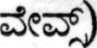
ವೇವ್ಸ್)
